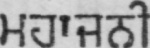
ਮਹਾਜਨੀ
